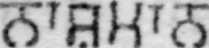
ਨਾਸ਼ਮਾਨ
